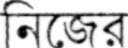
নিজের
